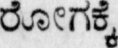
ರೋಗಕ್ಕೆ
